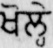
ਖੋਲ੍ਹੇ
